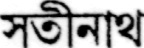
সতীনাথ
